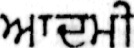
ਆਦਮੀ
